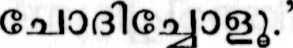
ചോദിച്ചോളൂ.’
